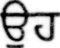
ਉਹ
